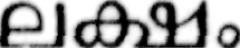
ലക്ഷം
